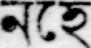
নহে
